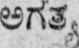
ಅಗತ್ಯ
